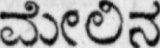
ಮೇಲಿನ
